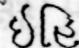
ઈહિ
